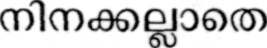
നിനക്കല്ലാതെ
